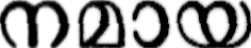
നമായ
